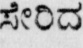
ಸೇರಿದ
